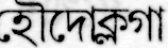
হৌদোক্লগা
